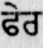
ਫੇਰ
